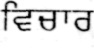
ਵਿਚਾਰ
